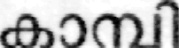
കാമ്പി
